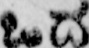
ಒದ
